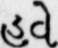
હવે
